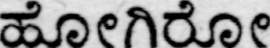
ಹೋಗಿರೋ
